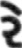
રે
